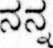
ನನ್ನ
